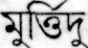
মুর্ত্তিদু
